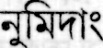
নুমিদাং
